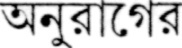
অনুরাগের
